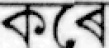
কৰে
